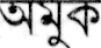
অমুক
